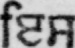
ਇਸ
